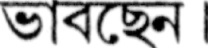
ভাবছেন।
